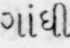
ગાંધી
